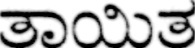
ತಾಯಿತ
